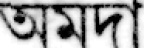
অমদা
